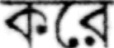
করে
